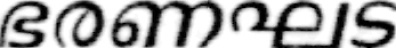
ഭരണഘട
